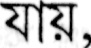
যায়,
